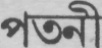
পতনী
